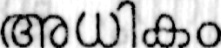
അധികം
